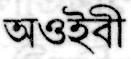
অওইবী
